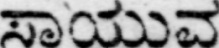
ಸಾಯುವ
